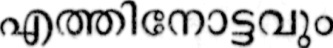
എത്തിനോട്ടവും
